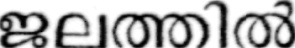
ജലത്തില്‍
